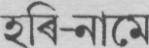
হৰি-নামে
